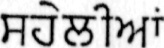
ਸਹੇਲੀਆਂ
